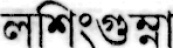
লশিংগুম্না
